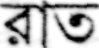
রাত
